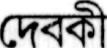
দেবকী
